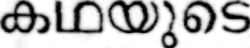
കഥയുടെ
